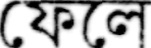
ফেলে
